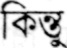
কিন্তু
